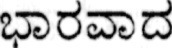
ಭಾರವಾದ
